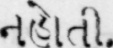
નહોતી.
